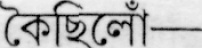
কৈছিলোঁ-
